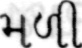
મળી
